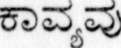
ಕಾವ್ಯವು
